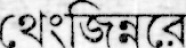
থেংজিন্নরে
